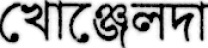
খোঞ্জেলদা
